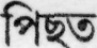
পিছত
